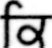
ਕਿ
